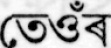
তেওঁৰ
